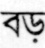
বড়
